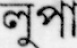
লুপা
